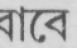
বাবে
